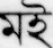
মই
